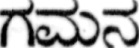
ಗಮನ
